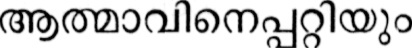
ആത്മാവിനെപ്പറ്റിയും
